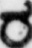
ರ
